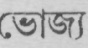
ভোজ্য
